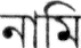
নামি
